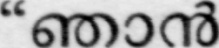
"ഞാന്‍
